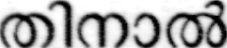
തിനാല്‍
